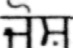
ਜੋਸ਼
